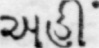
અહીં
